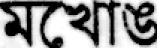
মখোঙ
